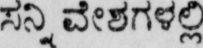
ಸನ್ನಿವೇಶಗಳಲ್ಲಿ
